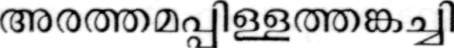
അരത്തമപ്പിള്ളത്തങ്കച്ചി
